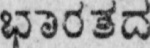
ಭಾರತದ
